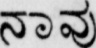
ನಾವು
